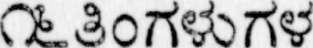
೧೬ತಿಂಗಳುಗಳ
